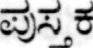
ಪುಸ್ತಕ
